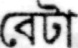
বেটা
